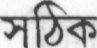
সঠিক
